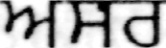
ਅਸਰ
